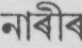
নাৰীৰ
